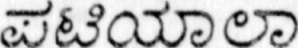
ಪಟಿಯಾಲಾ
